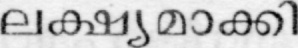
ലക്ഷ്യമാക്കി
